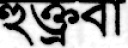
হুক্ত্রবা
